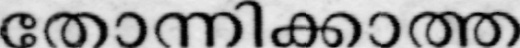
തോന്നിക്കാത്ത
